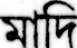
মাদি
